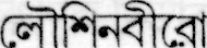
লৌশিনবীরো
